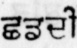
ਛਡਦੀ
